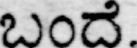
ಬಂದೆ.
